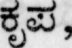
ಕೃಪ,
